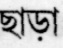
ছাড়া
